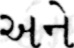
અને
